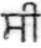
ਸੀ
